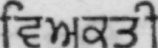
ਵਿਅਕਤੀ
